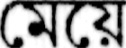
মেয়ে
